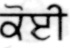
ਕੋਈ
